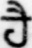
ਹੈ
